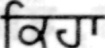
ਕਿਹਾ
